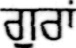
ਗੁਰਾਂ
